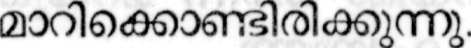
മാറിക്കൊണ്ടിരിക്കുന്നു.
